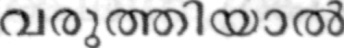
വരുത്തിയാല്‍
